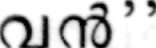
വന്‍"
